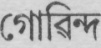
গোৱিন্দ
